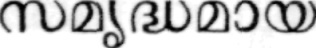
സമൃദ്ധമായ
